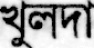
খুলদা
